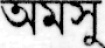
অমসু
